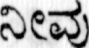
ನೀವು
